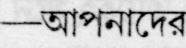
–আপনাদের
